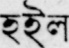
হইল
